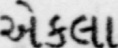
એકલા
